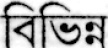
বিভিন্ন
